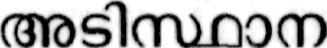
അടിസ്ഥാന
